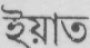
ইয়াত
